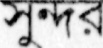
সুন্দর
